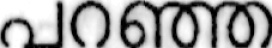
പറഞ്ഞ
